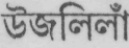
উজলিলাঁ
